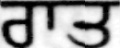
ਰਾਤ
